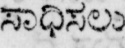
ಸಾಧಿಸಲು
